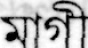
মাগী
